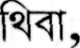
থিবা,
